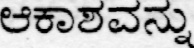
ಆಕಾಶವನ್ನು
